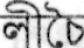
লীচৈ
